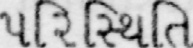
પરિસ્થિતિ
